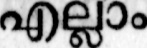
എല്ലാം
